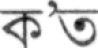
ক'ত
